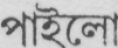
পাইলো
